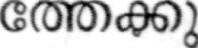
ത്തേക്കു
